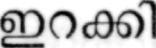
ഇറക്കി
